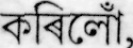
কৰিলোঁ,
